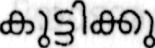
കുട്ടിക്കു
